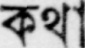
কথা
